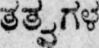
ತತ್ವಗಳ
